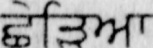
ਛੇੜਿਆ
